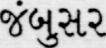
જંબુસર
